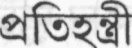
প্রতিহন্ত্রী
